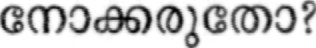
നോക്കരുതോ?
